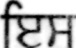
ਇਸ
